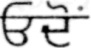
ਓਦੋਂ
